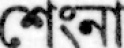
শেংনা
